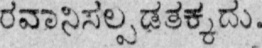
ರವಾನಿಸಲ್ಪಡತಕ್ಕದು.
